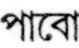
পাবো
